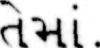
તેમાં.
